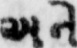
અને
